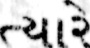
ત્યારે
